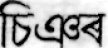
চিঞৰ
